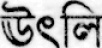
ঊৎলি
